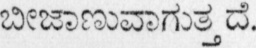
ಬೀಜಾಣುವಾಗುತ್ತದೆ.
